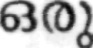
ഒരു
